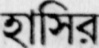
হাসির
